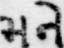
મને
